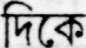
দিকে
